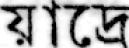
য়াদ্রে
